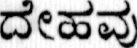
ದೇಹವು
